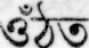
ওঁঠত
